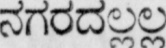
ನಗರದಲ್ಲಲ್ಲ
